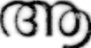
ആ
